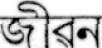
জীৱন
